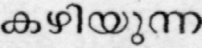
കഴിയുന്ന
